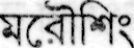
মরৌশিং
